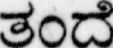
ತಂದೆ
